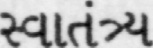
સ્વાતંત્ર્ય
